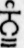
ਨੂੰ
